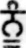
ਨੂੰ
